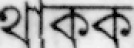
থাকক
